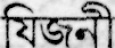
যিজনী
